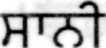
ਸਾਨੀ
